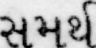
સમર્થ
